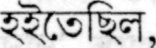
হইতেছিল,
